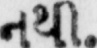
નથી.
